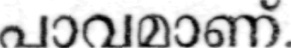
പാവമാണ്.
